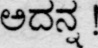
ಅದನ್ನ!
